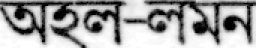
অহল-লমন
